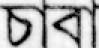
চাবা
